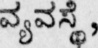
ವ್ಯವಸ್ಥೆ,
